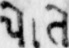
પોતે
